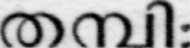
തമ്പി:
